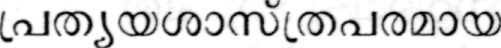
പ്രത്യയശാസ്ത്രപരമായ
